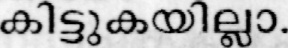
കിട്ടുകയില്ലാ.
